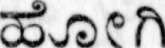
ಹೋಗಿ
